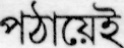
পঠায়েই
